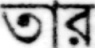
তার
